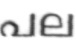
പല
